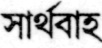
সার্থবাহ
